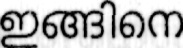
ഇങ്ങിനെ
